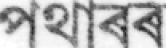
পথাৰৰ
